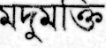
মদুমক্তি
